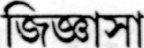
জিজ্ঞাসা
